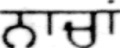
ਨਾਚਾਂ
